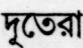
দূতেরা
